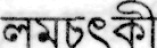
লমচৎকী
